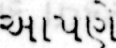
આપણે
